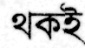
থকই
